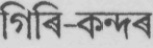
গিৰি-কন্দৰ
